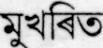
মুখৰিত
